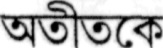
অতীতকে
